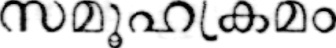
സമൂഹക്രമം
